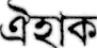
ঐহাক
